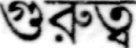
গুরুত্ব
